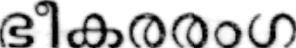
ഭീകരരംഗ
